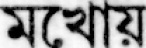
মখোয়
